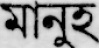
মানুহ
